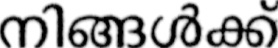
നിങ്ങള്‍ക്ക്
